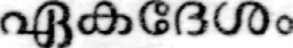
ഏകദേശം
